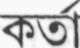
কর্তা
